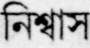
নিশ্বাস
